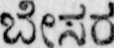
ಬೇಸರ
